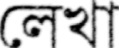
লেখা
